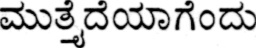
ಮುತ್ತೈದೆಯಾಗೆಂದು
